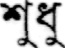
শুধু
